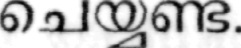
ചെയ്യണ്ട.
